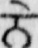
ਨੇ
